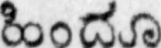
ಹಿಂದೂ
